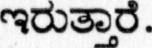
ಇರುತ್ತಾರೆ.
